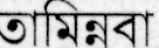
তামিন্নবা
